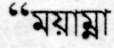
“ময়াম্না
